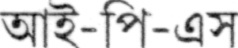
আই-পি-এস
